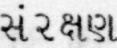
સંરક્ષણ
